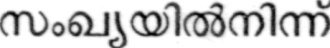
സംഖ്യയില്‍നിന്ന്
